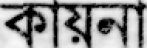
কায়না
